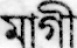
মাগী
